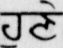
ਹੁਣੇ
